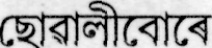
ছোৱালীবোৰে
